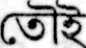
তৌই
